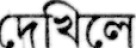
দেখিলে
